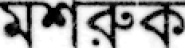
মশরুক
